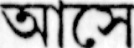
আসে
